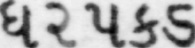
ધરપકડ
